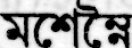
মশেম্নৈ
